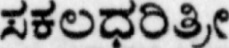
ಸಕಲಧರಿತ್ರೀ
